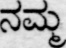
ನಮ್ಮ
